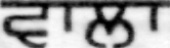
ਵਾਲਾ
